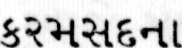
કરમસદના
